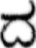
ದ
